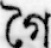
গৈ
